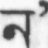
ন’
